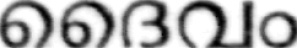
ദൈവം
